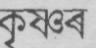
কৃষ্ণৰ
